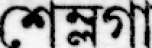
শেম্লগা
